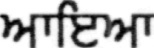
ਆਇਆ
